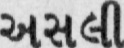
અસલી
